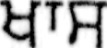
ਖਾਸ
